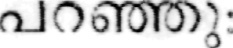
പറഞ്ഞു:
